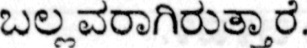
ಬಲ್ಲವರಾಗಿರುತ್ತಾರೆ.
